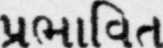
પ્રભાવિત
